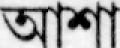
আশা
